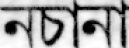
নচানা
